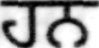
ਹਨ
